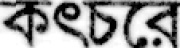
কৎচরে
